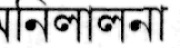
মনিলালনা
